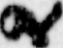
જ
